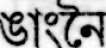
ঙাংনৈ
